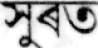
সুৰত
